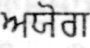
ਅਯੋਗ
